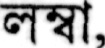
লম্বা,
